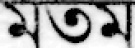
মতম
